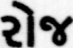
રોજ
